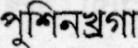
পুশিনখ্রগা
